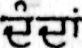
ਦੰਦਾਂ
